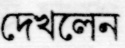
দেখলেন
